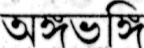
অঙ্গভঙ্গি
